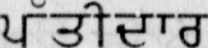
ਪੱਤੀਦਾਰ
